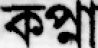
কপ্না
